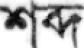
শব্দ
